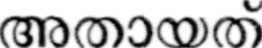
അതായത്
